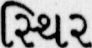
સ્થિર
